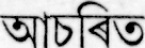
আচৰিত
